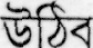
উঠিব
